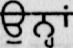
ਉਨ੍ਹਾਂ
